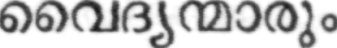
വൈദ്യന്മാരും
